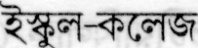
ইস্কুল-কলেজ
